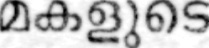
മകളുടെ
